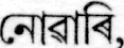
নোৱাৰি,
